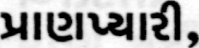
પ્રાણપ્યારી,
